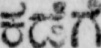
ಕಡೆಗೆ
